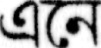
এনে
